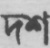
দশ
